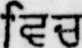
ਵਿਚ
